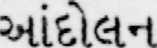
આંદોલન
